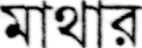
মাথার
